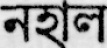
নহাল
